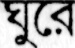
ঘুরে
